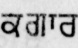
ਕਗਾਰ
